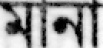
মানা
